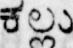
ಕಲ್ಲು
